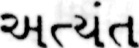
અત્યંત
